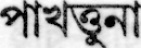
পাখত্তুনা
